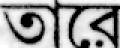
তারে
